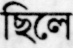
ছিলে
